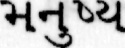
મનુષ્ય
